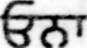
ਓਨਾ
